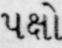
પક્ષો
